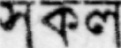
সকল
